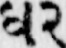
ઘર
